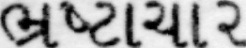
ભ્રષ્ટાચાર
